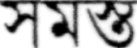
সমস্ত
